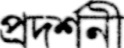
প্রদর্শনী
